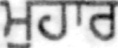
ਮੁਹਾਰ
